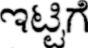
ಇಟ್ಟಿಗೆ
